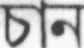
চান
